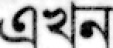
এখন
